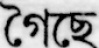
গৈছে
